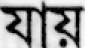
যায়
